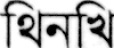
থিনখি
